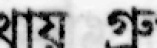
থায় গ্রু
